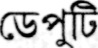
ডেপুটি
